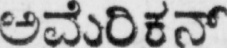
ಅಮೆರಿಕನ್
